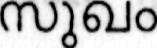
സുഖം
